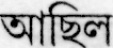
আছিল
